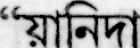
“য়ানিদা
